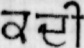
ਕਦੀ
